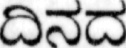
ದಿನದ
